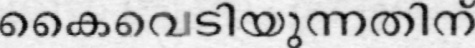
കൈവെടിയുന്നതിന്
